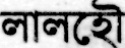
লালহৌ
